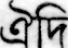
ঐদি
